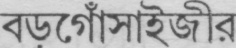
বড়গোঁসাইজীর
